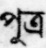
পুত্র
